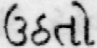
ઉઠતો
